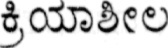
ಕ್ರಿಯಾಶೀಲ
